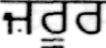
ਜ਼ਰੂਰ
